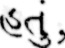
હતું,
